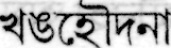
খঙহৌদনা
